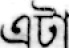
এটা
